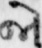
જો
